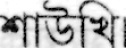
শাউখি।
